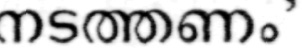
നടത്തണം’
